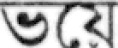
ভয়ে
